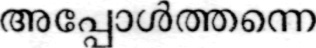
അപ്പോള്‍ത്തന്നെ
